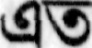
এত
